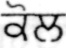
ਕੋਲ
